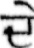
ਦੇ
